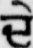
ਦੇ
